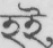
হই,
